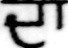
ਦਾ
